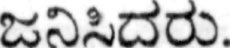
ಜನಿಸಿದರು.
